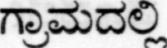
ಗ್ರಾಮದಲ್ಲಿ
